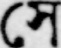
সে
